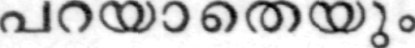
പറയാതെയും
